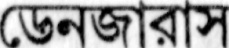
ডেনজারাস
